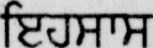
ਇਹਸਾਸ
